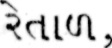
રેતાળ,
